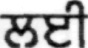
ਲਈ
